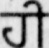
ਹੀ
